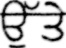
ਉੱਤੇ
